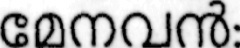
മേനവന്‍:
